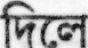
দিলে
